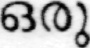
ഒരു
